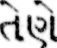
તેણે
